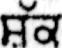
ਸ਼ੱਕ
